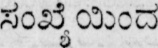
ಸಂಖ್ಯೆಯಿಂದ
